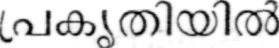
പ്രകൃതിയില്‍
